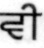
ਵੀ
